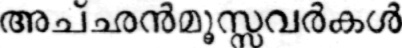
അച്ഛന്‍മൂസ്സവര്‍കള്‍
